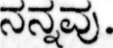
ನನ್ನವು.
